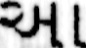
આ
